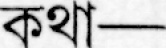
কথা-
